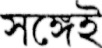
সঙ্গেই
